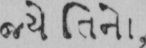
જ્યોતિનો,
